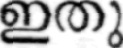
ഇതു
